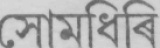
সোমধিৰি
